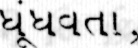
ધૂંધવતા,
